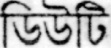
ডিউটি
